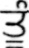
ਤੂੰ
